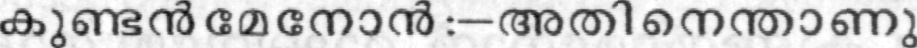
കുണ്ടന്‍മേനോന്‍:-അതിനെന്താണു
